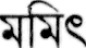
মমিৎ
